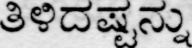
ತಿಳಿದಷ್ಟನ್ನು
